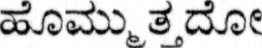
ಹೊಮ್ಮುತ್ತದೋ
